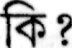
কি?
